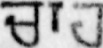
ਚਾਹ
